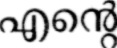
എന്റെ
